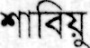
শাবিয়ু
